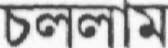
চললাম
